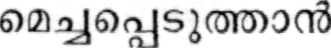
മെച്ചപ്പെടുത്താന്‍
